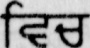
ਵਿਚ
